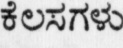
ಕೆಲಸಗಳು
